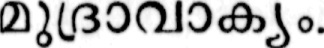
മുദ്രാവാക്യം.
